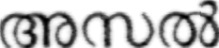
അസല്‍
